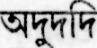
অদুদদি
